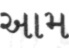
આમ
